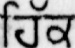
ਹਿੱਕ
